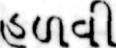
હળવી
